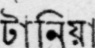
টানিয়া
